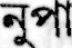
নুপা
